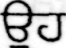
ਉਹ
